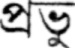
প্রভু
